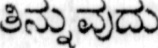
ತಿನ್ನುವುದು
